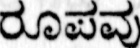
ರೂಪವು
